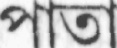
পাতা
